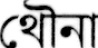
থৌনা
